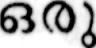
ഒരു
